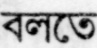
বলতে
